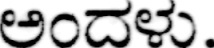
ಅಂದಳು.
